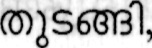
തുടങ്ങി,
